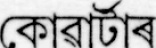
কোৱাৰ্টাৰ
